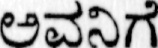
ಅವನಿಗೆ
